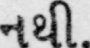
નથી.
